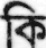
কি
